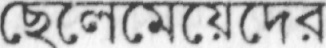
ছেলেমেয়েদের
